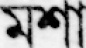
মশা
